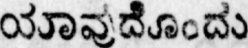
ಯಾವುದೊಂದು
